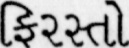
ફિરસ્તો
